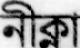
নীক্না
